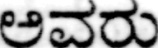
ಅವರು
